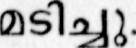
മടിച്ചു.
